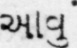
આવું
